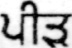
ਪੀੜ
